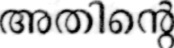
അതിന്റെ
